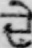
ਦੇ
